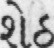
શેઠ
